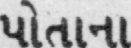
પોતાના
